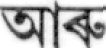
আৰু
